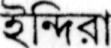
ইন্দিরা
